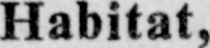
Habitat,
